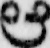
ಆ
